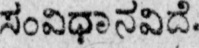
ಸಂವಿಧಾನವಿದೆ.
